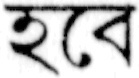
হবে
